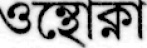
ওন্থোক্না
